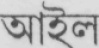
আইল
